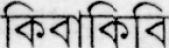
কিবাকিবি
